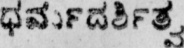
ದರ್ಮದರ್ಶಿತ್ವ
